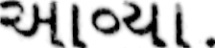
આવ્યા.
